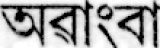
অৱাংবা
